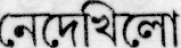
নেদেখিলো
